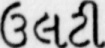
ઉલટી
